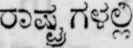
ರಾಷ್ಟ್ರಗಳಲ್ಲಿ
